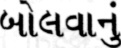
બોલવાનું
